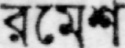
রমেশ
